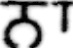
ਨਾ
